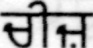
ਚੀਜ਼
